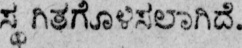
ಸ್ಥಗಿತಗೊಳಿಸಲಾಗಿದೆ.
